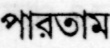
পারতাম
